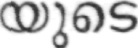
യുടെ
